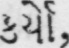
કર્યો,
